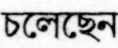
চলেছেন
